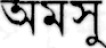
অমসু
